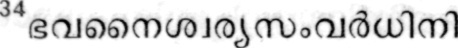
34ഭവനൈശ്വര്യസംവര്‍ധിനി
